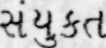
સંયુક્ત
